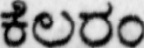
ಕೆಲರಂ
